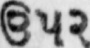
ઉપર
